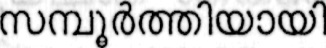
സമ്പൂര്‍ത്തിയായി
